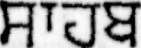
ਸਾਹਬ
